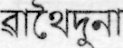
ৱাথৈদুনা
